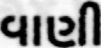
વાણી
